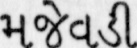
મજેવડી
